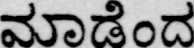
ಮಾಡೆಂದ
